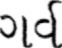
ગર્વ
